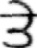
ਤੇ
